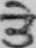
ਤੇ
